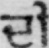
ਦੀ
